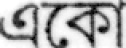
একো
